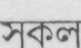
সকল
